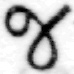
જ
